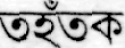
তহঁতক
